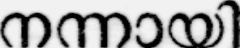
നന്നായി
